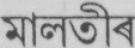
মালতীৰ
